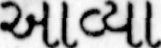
આવ્યા
